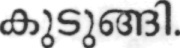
കുടുങ്ങി.
